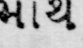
માથે
